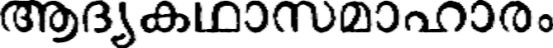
ആദ്യകഥാസമാഹാരം
